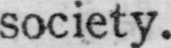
society.
